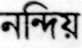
নন্দিয়
